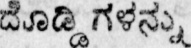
ದೊಡ್ಡಿಗಳನ್ನು
